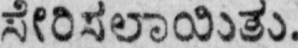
ಸೇರಿಸಲಾಯಿತು.
